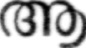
ആ
